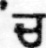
'ਚ
